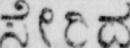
ಸೇರಿದ
